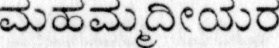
ಮಹಮ್ಮದೀಯರ
